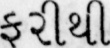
ફરીથી
